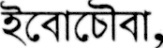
ইবোচৌবা,
